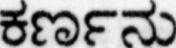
ಕರ್ಣನು
